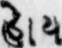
હોય
